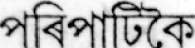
পৰিপাটিকৈ
